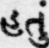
હતું
